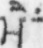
ਮੈਂ
